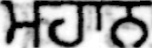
ਮਹਾਨ
